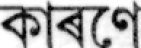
কাৰণে
